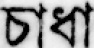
চাধা
